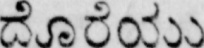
ದೊರೆಯು
